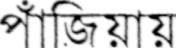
পাঁজিয়ায়
